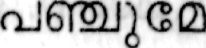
പഞ്ചുമേ
